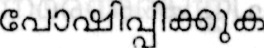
പോഷിപ്പിക്കുക
